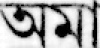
অমা
